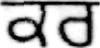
ਕਰ
